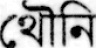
থৌনি
